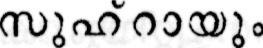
സുഹ്റായും
